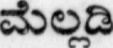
ಮೆಲ್ಲಡಿ
